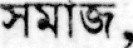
সমাজ,
